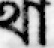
থা
